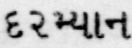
દરમ્યાન
